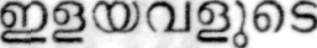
ഇളയവളുടെ
